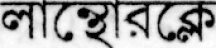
লান্থোরক্লে
